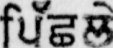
ਪਿੱਛਲੇ
